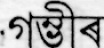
গম্ভীৰ
